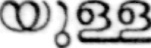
യുള്ള
